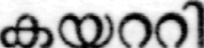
കയററി
